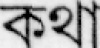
কথা
